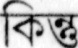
কিন্তু
